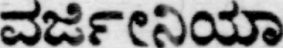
ವರ್ಜೀನಿಯಾ
